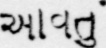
આવતું
